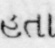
હતા
